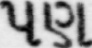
પણ
